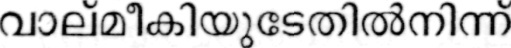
വാല്മീകിയുടേതില്‍നിന്ന്
